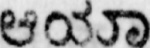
ಆಯಾ
